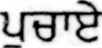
ਪੁਚਾਏ
